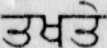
ਤਖਤੇ
